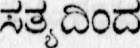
ಸತ್ಯದಿಂದ
